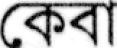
কেবা
